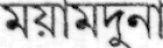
ময়ামদুনা
